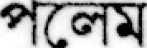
পলেম
